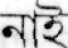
নাই
